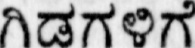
ಗಿಡಗಳಿಗೆ
